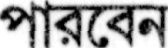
পারবেন
